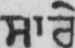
ਸਾਰੇ
